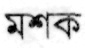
মশক
